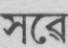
সৱে
